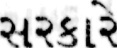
સરકારે
